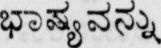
ಭಾಷ್ಯವನ್ನು
